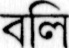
বলি
